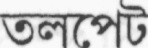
তলপেট
